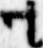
ન
